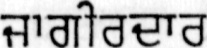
ਜਾਗੀਰਦਾਰ
